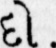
દો.
